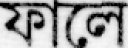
ফালে
